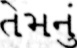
તેમનું
